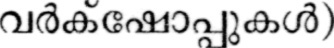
വര്‍ക്ഷോപ്പുകള്‍)
